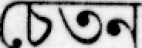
চেতন
